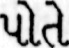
પોતે
